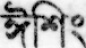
ঈশিং
